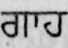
ਗਾਹ
